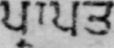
ਪ੍ਰਾਪਤ
